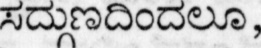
ಸದ್ಗುಣದಿಂದಲೂ,
